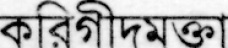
করিগীদমক্তা
